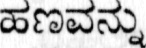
ಹಣವನ್ನು
